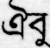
ঐবু
